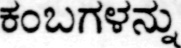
ಕಂಬಗಳನ್ನು
